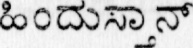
ಹಿಂದುಸ್ತಾನ್
